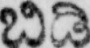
ಬಿಡಿ
